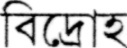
বিদ্রোহ
